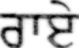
ਰਾਏ
